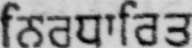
ਨਿਰਧਾਰਿਤ
